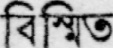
বিস্মিত
